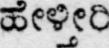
ಹೇಳ್ತೀರಿ
